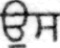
ਉਸ
